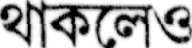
থাকলেও
